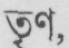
তৃণ,
